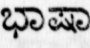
ಭಾಷಾ
